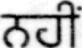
ਨਹੀਂ
